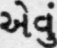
એવું
